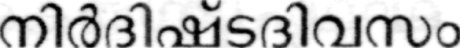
നിര്‍ദിഷ്ടദിവസം
